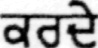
ਕਰਦੇ
